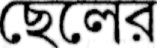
ছেলের
